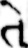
તે
